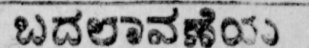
ಬದಲಾವಣೆಯ
